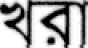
খরা
